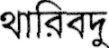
থারিবদু
